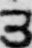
ਤ
